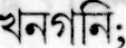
খনগনি;
